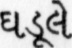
ઘડૂલે
